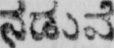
ನಡುವೆ
